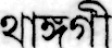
থাঙ্গগী
